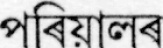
পৰিয়ালৰ
